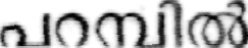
പറമ്പില്‍
